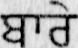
ਬਾਰੇ
